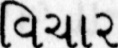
વિચાર
